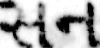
સન
